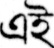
এই
